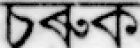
চৰুক
